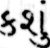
કશું
